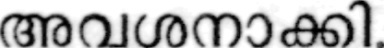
അവശനാക്കി.
